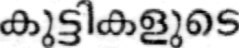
കുട്ടികളുടെ
